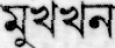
মুখখন
